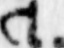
ત.
